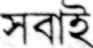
সবাই
